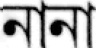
নানা
